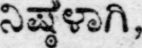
ನಿಷ್ಠಳಾಗಿ,
